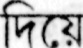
দিয়ে
